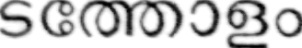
ടത്തോളം
